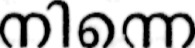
നിന്നെ
